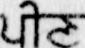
ਪੀਣ
